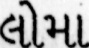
લોમા
